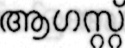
ആഗസ്റ്റ്
